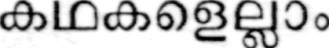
കഥകളെല്ലാം
